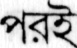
পরই
